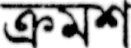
ক্রমশ
